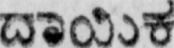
ದಾಯಿಕ
